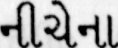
નીચેના
